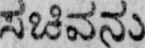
ಸಚಿವನು
